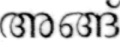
അങ്ങ്
